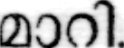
മാറി.
